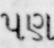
પણ
